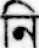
নি
